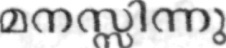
മനസ്സിന്നു
